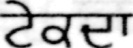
ਟੇਕਦਾ
